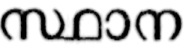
സ്ഥാന
